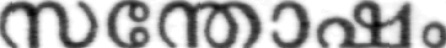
സന്തോഷം
